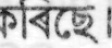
কৰিছে
